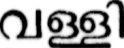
വള്ളി
